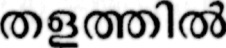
തളത്തില്‍
